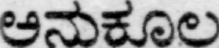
ಅನುಕೂಲ
